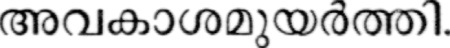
അവകാശമുയര്‍ത്തി.
